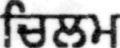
ਚਿਲਮ
